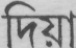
দিয়া
